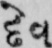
દેવ
